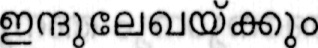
ഇന്ദുലേഖയ്ക്കും
